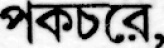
পকচরে,
